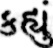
કહ્યું
